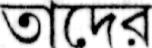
তাদের
